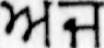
ਅਜ
